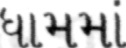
ધામમાં
